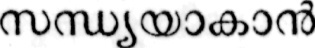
സന്ധ്യയാകാന്‍
